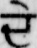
ਦੇ
